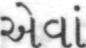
એવાં
